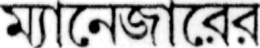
ম্যানেজারের
